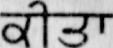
ਕੀਤਾ
